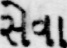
સેવા
